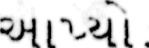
આપ્યો.
